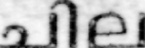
ചില
